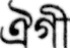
ঐগী
